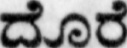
ದೊರೆ
